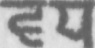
ਵਧ
